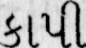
કાપી
